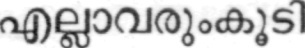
എല്ലാവരുംകൂടി
